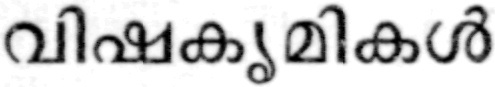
വിഷകൃമികള്‍
